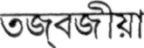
তজ্‌বজীয়া
